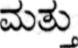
ಮತ್ತು
